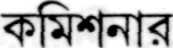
কমিশনার
